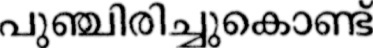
പുഞ്ചിരിച്ചുകൊണ്ട്
